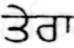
ਤੇਰਾ
